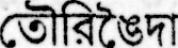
তৌরিঙৈদা
